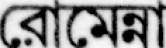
রোমেন্না
